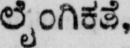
ಲೈಂಗಿಕತೆ,
